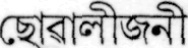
ছোৱালীজনী
